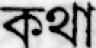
কথা
